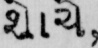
શોચે,
